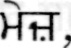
ਮੇਜ਼,
